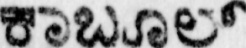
ಕಾಬೂಲ್
